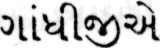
ગાંધીજીએ
